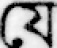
যে
